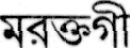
মরক্তগী
